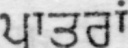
ਪਾਤਰਾਂ
